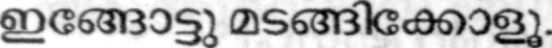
ഇങ്ങോട്ടുമടങ്ങിക്കോളൂ.
